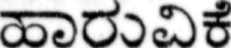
ಹಾರುವಿಕೆ
